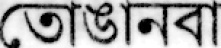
তোঙানবা
